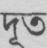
দূত
